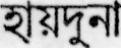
হায়দুনা
